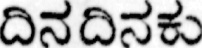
ದಿನದಿನಕು
